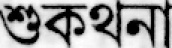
শুকথনা
